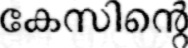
കേസിന്റെ
